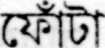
ফোঁটা
